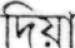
দিয়া
